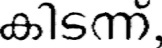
കിടന്ന്,
